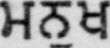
ਮਨੁਖ
